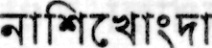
নাশিখোংদা
